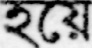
হয়ে
